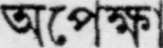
অপেক্ষা
